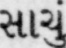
સાચું
